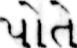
પોતે
